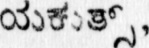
ಯಕುತ್ಸ್,
